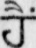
ਹੈਂ
